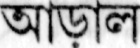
আড়াল
